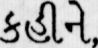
કહીને,
